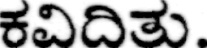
ಕವಿದಿತು.
